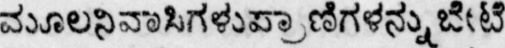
ಮೂಲನಿವಾಸಿಗಳುಪ್ರಾಣಿಗಳನ್ನುಬೇಟೆ
